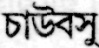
চাউবসু
